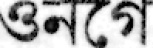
ওনগে
